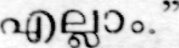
എല്ലാം.”
